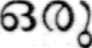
ഒരു
